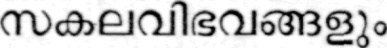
സകലവിഭവങ്ങളും
